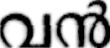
വന്‍
